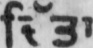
ਦਿੱਤਾ
